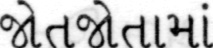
જોતજોતામાં
